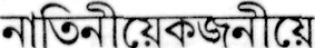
নাতিনীয়েকজনীয়ে
